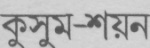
কুসুম-শয়ন
